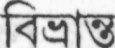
বিভ্রান্ত
